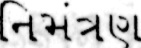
નિમંત્રણ
